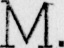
M.
